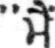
''ਮੈਂ
